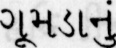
ગૂમડાનું
